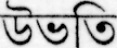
উভতি
